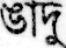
ঙাদু
